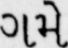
ગમે
